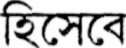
হিসেবে
